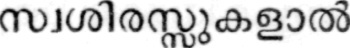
സ്വശിരസ്സുകളാല്‍
